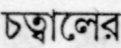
চত্বালের
